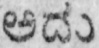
ಅದು
